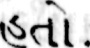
હતો.
